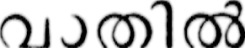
വാതില്‍
